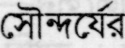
সৌন্দর্যের
